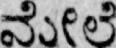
ಮೇಲೆ
